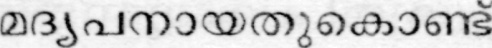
മദ്യപനായതുകൊണ്ട്
